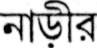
নাড়ীর
